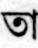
তা
